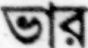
ভার
